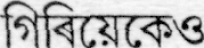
গিৰিয়েকেও
